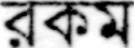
রকম
